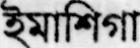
ইমাশিগা
